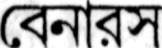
বেনারস
